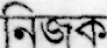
নিজক
